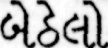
બેઠેલો
